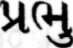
પ્રભુ
